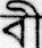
বী
